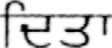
ਦਿਤਾ
